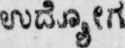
ಉದ್ಯೋಗ
